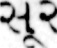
સૂર
